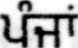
ਪੰਜਾਂ
